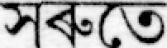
সৰুতে
